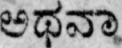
ಅಥವಾ
